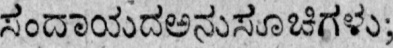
ಸಂದಾಯದಅನುಸೂಚಿಗಳು:
